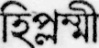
হিপ্লম্মী
